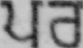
ਪਰ
